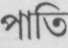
পাতি
